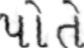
પોતે
